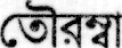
তৌরম্বা
